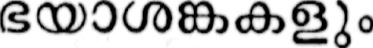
ഭയാശങ്കകളും
